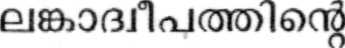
ലങ്കാദ്വീപത്തിന്റെ
